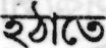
হঠাতে
